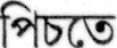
পিচতে
